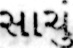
સાચું
